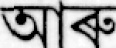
আৰু
